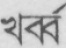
খৰ্ব্ব
